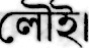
লৌই।
